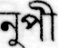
নুপী
